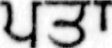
ਪਤਾ
